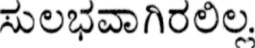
ಸುಲಭವಾಗಿರಲಿಲ್ಲ.
